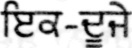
ਇਕ-ਦਂੂਜੇ
